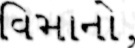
વિમાનો,
